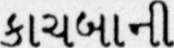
કાચબાની
